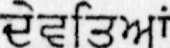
ਦੇਵਤਿਆਂ
